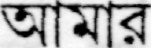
আমার
